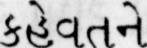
કહેવતને
